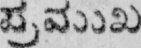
ಪ್ರಮುಖ
